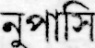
নুপাসি
